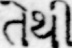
તેથી
